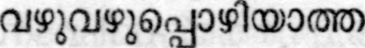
വഴുവഴുപ്പൊഴിയാത്ത
